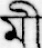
মী
